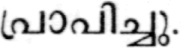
പ്രാപിച്ചു.
